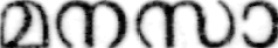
മനസാ
